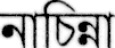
নাচিন্না
